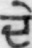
ਦੇ
